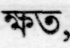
ক্ষত,
